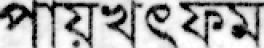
পায়খৎফম
